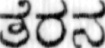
ತೆರನ
